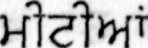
ਮੀਟੀਆਂ
